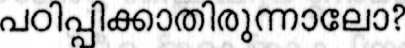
പഠിപ്പിക്കാതിരുന്നാലോ?
